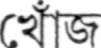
খোঁজ
